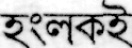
হংলকই
